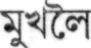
মুখলৈ
